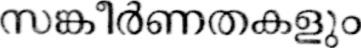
സങ്കീര്‍ണതകളും
